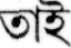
তাই
